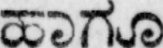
ಹಾಗೂ
